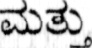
ಮತ್ತು
